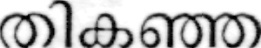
തികഞ്ഞ
